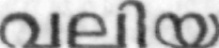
വലിയ
